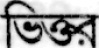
ভিক্তর
